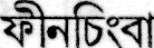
ফীনচিংবা
